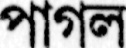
পাগল
